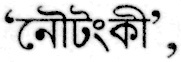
‘নৌটংকী’,
